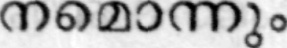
നമൊന്നും
